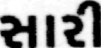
સારી
